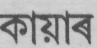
কায়াৰ
